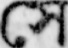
সে
